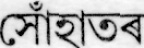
সোঁহাতৰ
